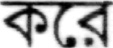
করে
